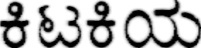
ಕಿಟಕಿಯ
